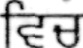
ਵਿਚ
